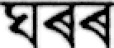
ঘৰৰ
